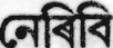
নেৰিবি
